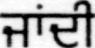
ਜਾਂਦੀ
